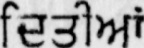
ਦਿਤੀਆਂ
